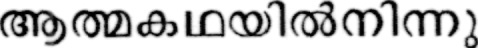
ആത്മകഥയില്‍നിന്നു
